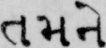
તમને
